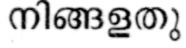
നിങ്ങളതു
